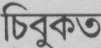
চিবুকত
